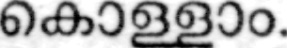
കൊള്ളാം.
